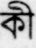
কী
